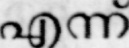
എന്ന്
